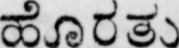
ಹೊರತು
